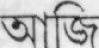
আজি
